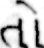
તો
